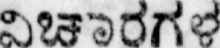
ವಿಚಾರಗಳ
